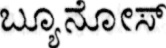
ಬ್ಯೂನೋಸ್
